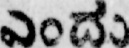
ಎಂದು
